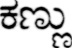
ಕಣ್ಣು
